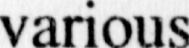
various
